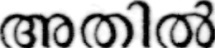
അതില്‍
